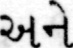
અને
